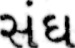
સંઘ
